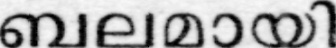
ബലമായി
